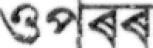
ওপৰৰ
